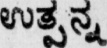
ಉತ್ಪನ್ನ
